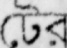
টের
